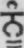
ਨੂੰ
